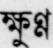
ক্ষুণ্ণ
